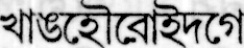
খাঙহৌরোইদগে
